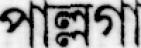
পাল্লগা
